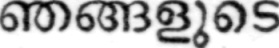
ഞങ്ങളുടെ
